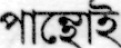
পান্থোই
